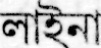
লাইনা
